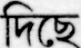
দিছে
